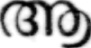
ആ
